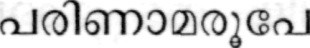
പരിണാമരൂപേ
